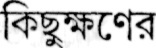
কিছুক্ষণের
